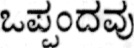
ಒಪ್ಪಂದವು
